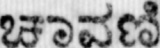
ಚಾವಣಿ
